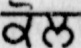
ਕੋਲ
